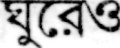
ঘুরেও
